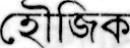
হৌজিক
